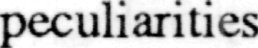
peculiarities
